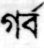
গর্ব
